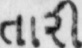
તારી
